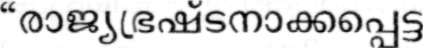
"രാജ്യഭ്രഷ്ടനാക്കപ്പെട്ട
